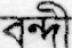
বন্দী
